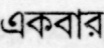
একবার
